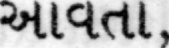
આવતા,
